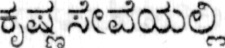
ಕೃಷ್ಣಸೇವೆಯಲ್ಲಿ
